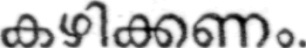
കഴിക്കണം.
